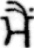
ਮੈਂ
